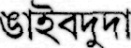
ঙাইবদুদা
